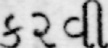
કરવી
